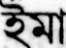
ইমা
